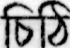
চিঠি
